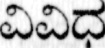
ವಿವಿಧ
